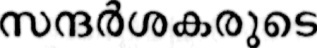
സന്ദര്‍ശകരുടെ
